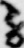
કે
